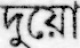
দুয়ো
